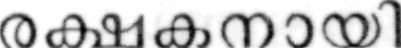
രക്ഷകനായി
